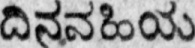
ದಿನವಹಿಯ
